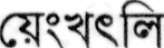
য়েংখৎলি
